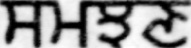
ਸਮਝਣ
